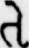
તે
